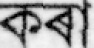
কৰা
